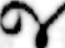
જ
